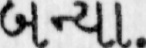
બન્યા.
